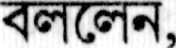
বললেন,
